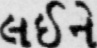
લઈને
